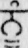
ਨੂੰ
